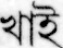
খাই
